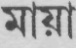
মায়া
